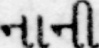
નાની
